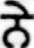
ਨੇ
